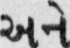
અને
